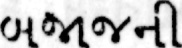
બજાજની
